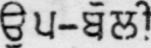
ਉਪ-ਬੋਲੀ
